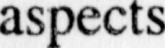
aspects
